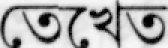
তেখেত
